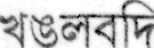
খঙলবদি
